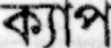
ক্যাপ
